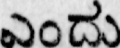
ಎಂದು
